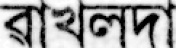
ৱাখলদা
